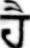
ਹੈ
